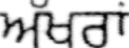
ਅੱਖਰਾਂ
